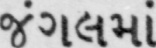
જંગલમાં
